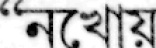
“নখোয়
